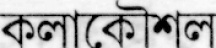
কলাকৌশল
